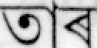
তাৰ
